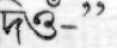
দিওঁ-"
